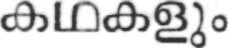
കഥകളും
